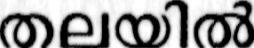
തലയില്‍
